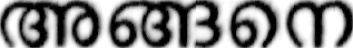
അങ്ങനെ
